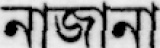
নাজানা
